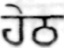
ਹੇਠ
